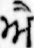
ਐ
